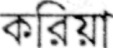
করিয়া
